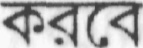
করবে
